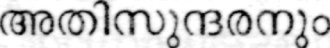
അതിസുന്ദരനും
